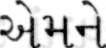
એમને
